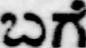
ಬಗೆ
